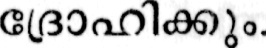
ദ്രോഹിക്കും.
